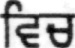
ਵਿਚ
